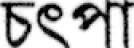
চৎপা
